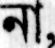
না,
